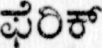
ಫೆರಿಕ್
